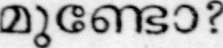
മുണ്ടോ?
